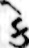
કે
